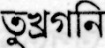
তুখ্রগনি
